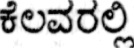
ಕೆಲವರಲ್ಲಿ
